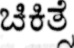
ಚಿಕಿತ್ಸೆ
